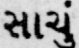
સાચું
